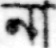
না
